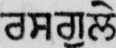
ਰਸਗੁਲੇ
